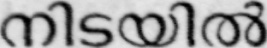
നിടയില്‍
